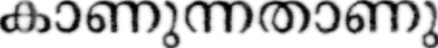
കാണുന്നതാണു
